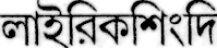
লাইরিকশিংদি
